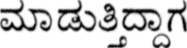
ಮಾಡುತ್ತಿದ್ದಾಗ
